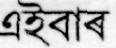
এইবাৰ
